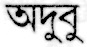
অবুদু
